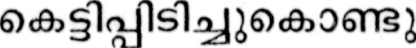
കെട്ടിപ്പിടിച്ചുകൊണ്ടു
